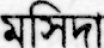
মসিদা
